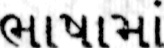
ભાષામાં
